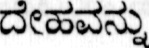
ದೇಹವನ್ನು
